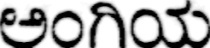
ಅಂಗಿಯ
